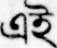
এই
